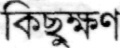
কিছুক্ষণ
